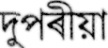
দুপৰীয়া
